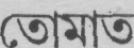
তোমাত
